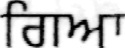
ਗਿਆ
